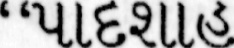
"પાદશાહ
